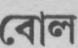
বোল
